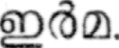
ഇര്‍മ.
